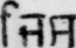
ਜਿਸ
